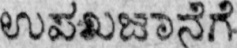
ಉಪಖಜಾನೆಗೆ
